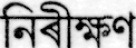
নিৰীক্ষণ
